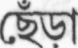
ছেঁড়া
